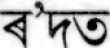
ৰ'দত
